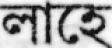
লাহে
